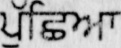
ਪੁੱਛਿਆ
